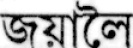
জয়ালৈ
